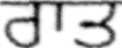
ਰਾਤ
